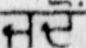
ਜਦੋਂ
